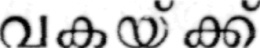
വകയ്ക്ക്
